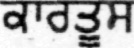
ਕਾਰਤੂਸ
